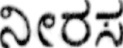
ನೀರಸ
